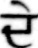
ਦੇ
